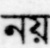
নয়
